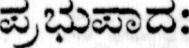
ಪ್ರಭುಪಾದ:
